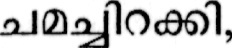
ചമച്ചിറക്കി,
